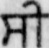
ਸੀ
